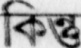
কিন্তু
